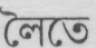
লৈতে
